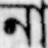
না
